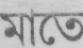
মাতে
